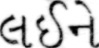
લઈને
